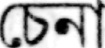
চেনা
